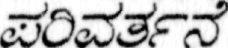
ಪರಿವರ್ತನೆ
